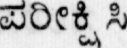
ಪರೀಕ್ಷಿಸಿ
